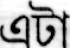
এটা
